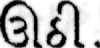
ઊઠી.
